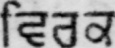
ਵਿਰਕ
